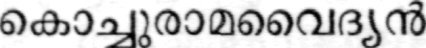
കൊച്ചുരാമവൈദ്യന്‍
